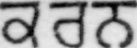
ਕਰਨ
